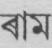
ৰাম
